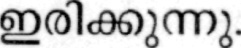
ഇരിക്കുന്നു.
